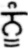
ਨੂੰ
